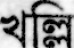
খল্লি
